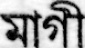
মাগী
